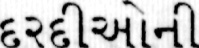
દરદીઓની
